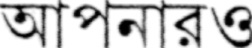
আপনারও
